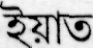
ইয়াত
